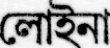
লোইনা
